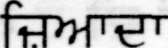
ਜ਼ਿਆਦਾ
